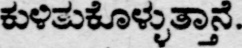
ಕುಳಿತುಕೊಳ್ಳುತ್ತಾನೆ.
